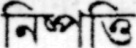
নিষ্পত্তি
